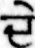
ਦੇ
